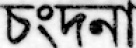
চংদনা
